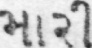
મારી
